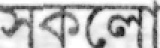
সকলো
